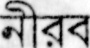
নীরব
